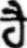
ਹੈ
